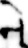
ને
